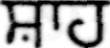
ਸ਼ਾਹ
